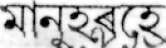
মানুহৰহে
